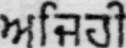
ਅਜਿਹੀ
